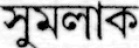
সুমলাক
